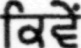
ਕਿਵੇਂ
